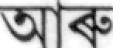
আৰু
